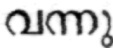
വന്നു
